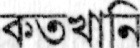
কতখানি
